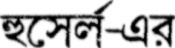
হুসের্ল-এর
